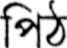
পিঠ
